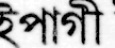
ইপাগী
